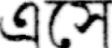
এসে
